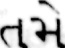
તમે
